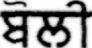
ਬੋਲੀ
